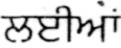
ਲਈਆਂ
